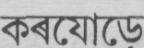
কৰযোড়ে
